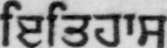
ਇਤਿਹਾਸ
